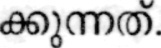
ക്കുന്നത്.
